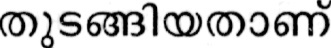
തുടങ്ങിയതാണ്
